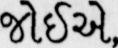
જોઈએ,
